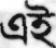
এই
